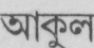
আকুল
